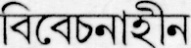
বিবেচনাহীন
